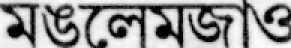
মঙলেমজাও
